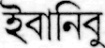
ইবানিবু
